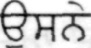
ਉਸਨੇ
